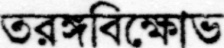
তরঙ্গবিক্ষোভ
